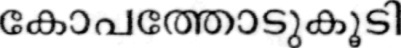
കോപത്തോടുകൂടി
